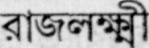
রাজলক্ষ্মী
